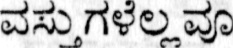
ವಸ್ತುಗಳೆಲ್ಲವೂ
